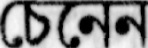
চেনেন
